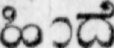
ಹಿಂದೆ
